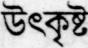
উত্কৃষ্ট
